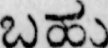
ಬಹು
